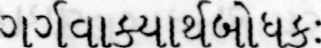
ગર્ગવાક્યાર્થબોધકઃ
